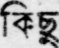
কিছু
